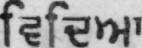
ਵਿਦਿਆ
